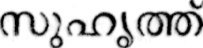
സുഹൃത്ത്
